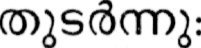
തുടര്‍ന്നു:
